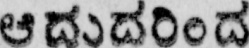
ಆದುದರಿಂದ
